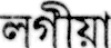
লগীয়া
